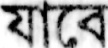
যাবে
